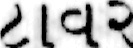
ટાવર
